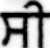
ਸੀ
